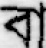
বা
